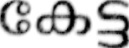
കേട്ട
